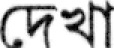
দেখা
